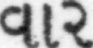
વાર
